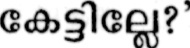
കേട്ടില്ലേ?’
